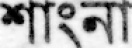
শাংনা
